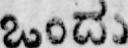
ಒಂದು
